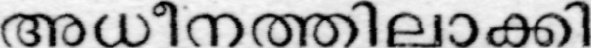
അധീനത്തിലാക്കി
